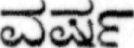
ವರ್ಷ
